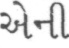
એની
